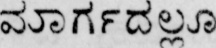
ಮಾರ್ಗದಲ್ಲೂ
